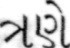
ત્રણે
